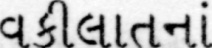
વકીલાતનાં
